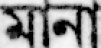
মানা
